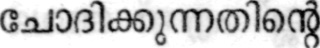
ചോദിക്കുന്നതിന്റെ
